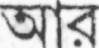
আর
